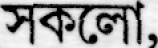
সকলো,
